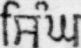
ਸਿੰਘ
